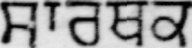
ਸਾਰਥਕ
